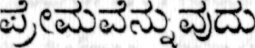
ಪ್ರೇಮವೆನ್ನುವುದು
